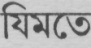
যিমতে
